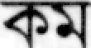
কম
